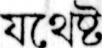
যথেষ্ট
